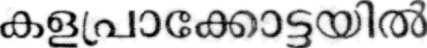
കളപ്രാക്കോട്ടയില്‍
